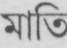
মাতি
